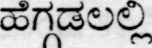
ಹೆಗ್ಗಡಲಲ್ಲಿ
